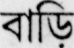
বাড়ি
